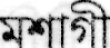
মশাগী
